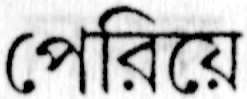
পেরিয়ে
